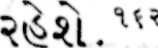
રહેશે.૧૬૨
